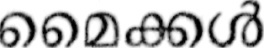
മൈക്കള്‍
